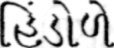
હિંડોળે
